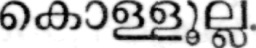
കൊള്ളൂല്ല.
